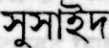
সুসাইদ
